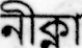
নীক্না
